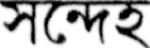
সন্দেহ
